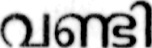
വണ്ടി
